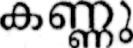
കണ്ണു
